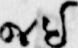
જઈ
